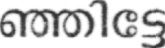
ഞ്ഞിട്ടേ
